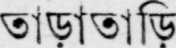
তাড়াতাড়ি
